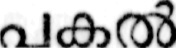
പകല്‍
